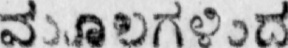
ಮೂಲಗಳಿಂದ
